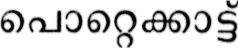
പൊറ്റെക്കാട്ട്
